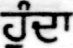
ਹੁੰਦਾ
